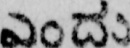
ಎಂದು
